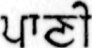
ਪਾਣੀ
